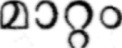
മാറ്റം
